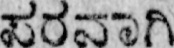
ಪರವಾಗಿ
